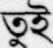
তুই
